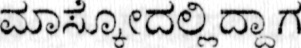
ಮಾಸ್ಕೋದಲ್ಲಿದ್ದಾಗ
